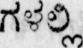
ಗಳಲ್ಲಿ
